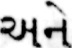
અને
